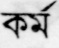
কর্ম
